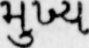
મુખ્ય
